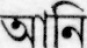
আনি
